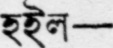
হইল—
